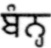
ਬੰਨ੍ਹ
